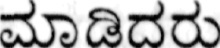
ಮಾಡಿದರು
